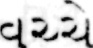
વચ્ચે
